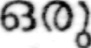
ഒരു
